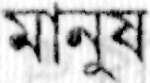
মানুষ
